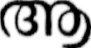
ആ
